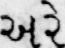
અરે
